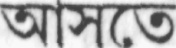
আসতে
